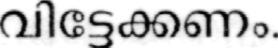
വിട്ടേക്കണം.
